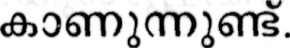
കാണുന്നുണ്ട്.
